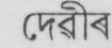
দেৱীৰ
